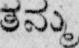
ತಮ್ಮ
